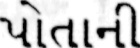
પોતાની
